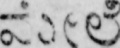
ಮೇಲೆ
